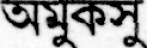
অমুকসু
